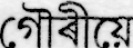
গৌৰীয়ে
